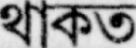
থাকত
